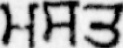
ਮਸਤ
